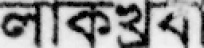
লাকখ্রবা
